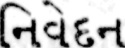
નિવેદન
